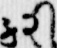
કરી
